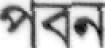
পবন
